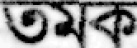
তমক
